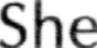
She
